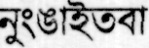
নুংঙাইতবা
